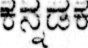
ಕನ್ನಡಕ
